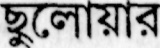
ছুলোয়ার
